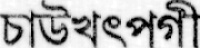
চাউখৎপগী
